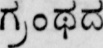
ಗ್ರಂಥದ
